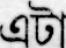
এটা
